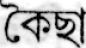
কৈছা
